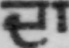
ਦਾ
